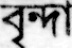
বৃন্দা
